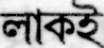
লাকই
